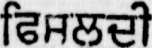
ਫਿਸਲਦੀ
